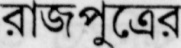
রাজপুত্রের
